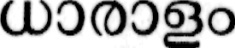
ധാരാളം
